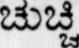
ಚುಚ್ಚಿ
